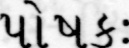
પોષકઃ
